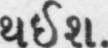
થઈશ.
